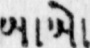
બાબો
